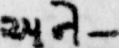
અને-
